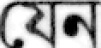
যেন
